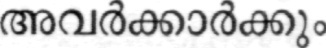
അവര്‍ക്കാര്‍ക്കും
